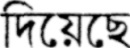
দিয়েছে
